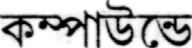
কম্পাউন্ডে
